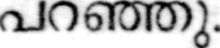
പറഞ്ഞു.
